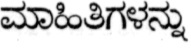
ಮಾಹಿತಿಗಳನ್ನು
